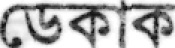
ডেকাক
